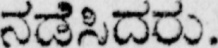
ನಡೆಸಿದರು.
